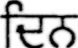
ਦਿਨ
